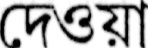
দেওয়া
